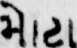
મોટા
